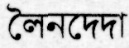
লৈনদেদা
